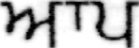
ਆਪ
